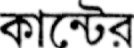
কান্টের
